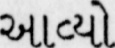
આવ્યો
